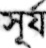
সূর্য
